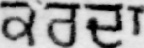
ਕਰਦਾ
